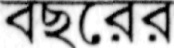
বছরের
